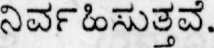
ನಿರ್ವಹಿಸುತ್ತವೆ.
